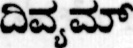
ದಿವ್ಯಮ್
